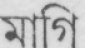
মাগি
